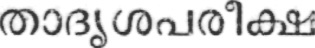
താദൃശപരീക്ഷ
